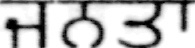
ਜਨਤਾ
